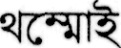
থম্মোই
